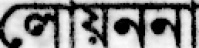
লোয়ননা
